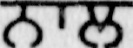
ਨਾਲ
